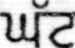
ਘੱਟ
